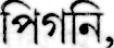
পিগনি,
